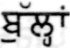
ਬੁੱਲ੍ਹਾਂ
